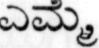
ಎಮ್ಮೆ,
